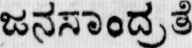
ಜನಸಾಂದ್ರತೆ
